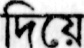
দিয়ে
